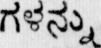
ಗಳನ್ನು
